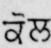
ਕੋਲ
